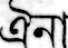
ঐনা
